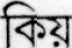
কিয়
